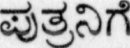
ಪುತ್ರನಿಗೆ
